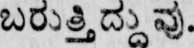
ಬರುತ್ತಿದ್ದುವು.
